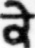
ਕੇ
